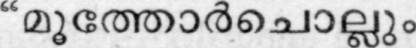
"മൂത്തോര്‍ചൊല്ലും
